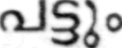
പട്ടും
